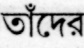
তাঁদের
